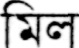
মিল
